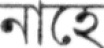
নাহে
